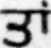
ਤਾਂ
